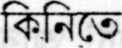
কিনিতে
